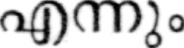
എന്നും
